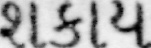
શકાય
